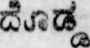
ದೊಡ್ಡ
